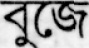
বুজে
